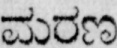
ಮರಣ
